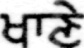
ਖਾਣੇ
